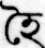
হৈ
